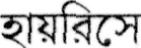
হায়রিসে
